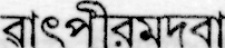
ৱাৎপীরমদবা
